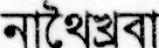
নাথৈখ্রবা
